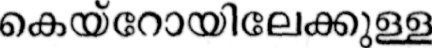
കെയ്റോയിലേക്കുള്ള
